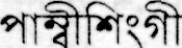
পাম্বীশিংগী
